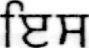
ਇਸ
